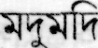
মদুমদি
